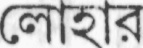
লোহার
